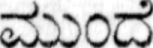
ಮುಂದೆ
